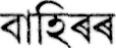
বাহিৰৰ
